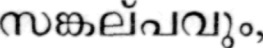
സങ്കല്പവും,
